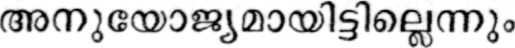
അനുയോജ്യമായിട്ടില്ലെന്നും
